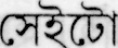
সেইটো
